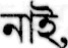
নাই,
